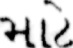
માટે
